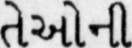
તેઓની
